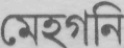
মেহগনি
